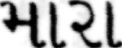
મારા
